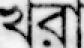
খরা
